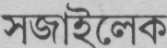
সজাইলেক
